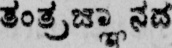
ತಂತ್ರಜ್ಞಾನದ
